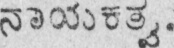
ನಾಯಕತ್ವ.
